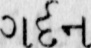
ગર્દન
